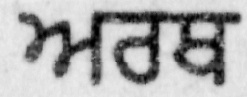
ਅਰਥ
